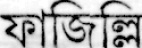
ফাজিল্লি
